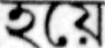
হয়ে
